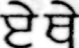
ਏਥੇ
